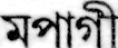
মপাগী
